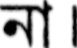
না।
